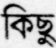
কিছু
